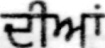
ਦੀਆਂ
